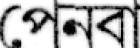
পেনবা
